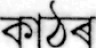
কাঠৰ
